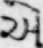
એ
